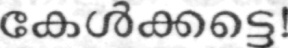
കേള്‍ക്കട്ടെ!
